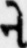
ને
